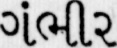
ગંભીર
